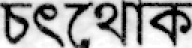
চৎখোক
